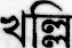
খল্লি
